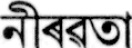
নীৰৱতা
